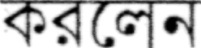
করলেন
